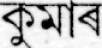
কুমাৰ
